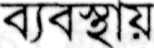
ব্যবস্থায়
